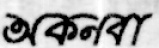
অকনবা
